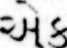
એક
